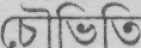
চৌভিতি
